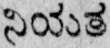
ನಿಯತ
